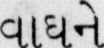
વાઘને
